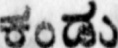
ಕಂಡು
